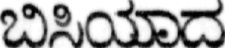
ಬಿಸಿಯಾದ
